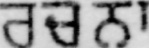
ਰਚਨਾ
